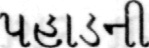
પહાડની
